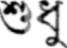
শুধু
